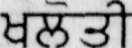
ਖਲੋਤੀ
